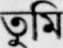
তুমি
